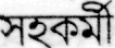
সহকর্মী
